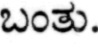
ಬಂತು.
